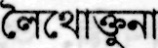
লৈথোক্তুনা
